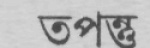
তপন্তু
